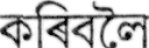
কৰিবলৈ
